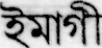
ইমাগী
